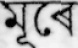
মূৰে
